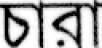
চারা
